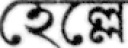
হেল্লে
